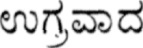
ಉಗ್ರವಾದ
